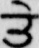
ਤੇ
